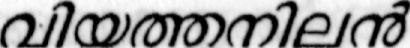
വിയത്തനിലന്‍
